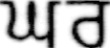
ਘਰ
